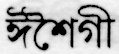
ঈশৈগী
